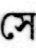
সে
